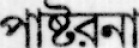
পাষ্টরনা
